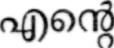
എന്റെ
